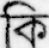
কি
